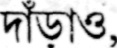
দাঁড়াও,
